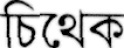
চিথেক
